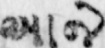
આજે
